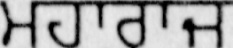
ਮਹਾਰਾਜ
